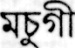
মচুগী
